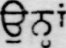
ਉਨ੍ਹਾਂ
